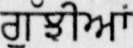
ਗੁੱਝੀਆਂ
